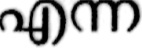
എന്ന
